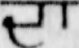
ਦਾ
